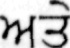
ਅਤੇ
